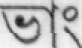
ভাং
